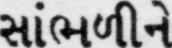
સાંભળીને
